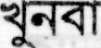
খুনবা
